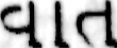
વાત
